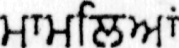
ਮਾਮਲਿਆਂ
